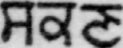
ਸਕਣ
